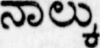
ನಾಲ್ಕು
